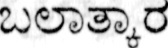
ಬಲಾತ್ಕಾರ
